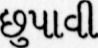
છુપાવી
